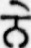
ਨੇ
